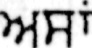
ਅਸਾਂ
